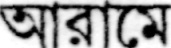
আরামে
